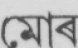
মোৰ
